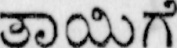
ತಾಯಿಗೆ
